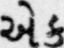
એક
